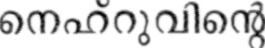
നെഹ്റുവിന്റെ
